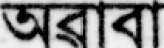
অৱাবা
